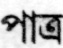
পাত্র
